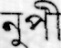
নুপী
